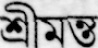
শ্রীমন্ত
